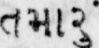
તમારું
